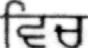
ਵਿਚ
